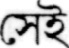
সেই
